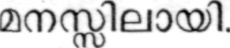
മനസ്സിലായി.
